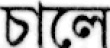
চালে
